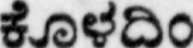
ಕೊಳದಿಂ
